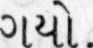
ગયો.
